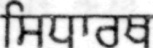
ਸਿਧਾਰਥ
